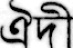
ঐদী
